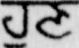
ਹੁਣ
